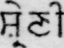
ਸ਼੍ਰੇਣੀ
